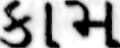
કામ
